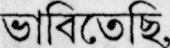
ভাবিতেছি,
